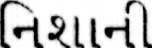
નિશાની
